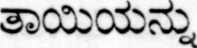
ತಾಯಿಯನ್ನು
